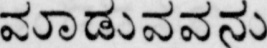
ಮಾಡುವವನು
